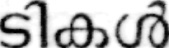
ടികള്‍
